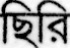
ছিরি
